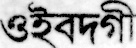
ওইবদগী
